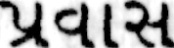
પ્રવાસ
